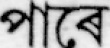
পাৰে
